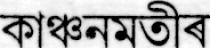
কাঞ্চনমতীৰ
